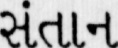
સંતાન
